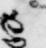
હું
